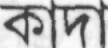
কাদা
